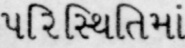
પરિસ્થિતિમાં
